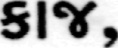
કાજ,
